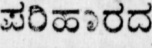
ಪರಿಹಾರದ
